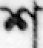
শ
